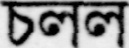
চলল
